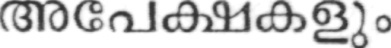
അപേക്ഷകളും
